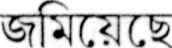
জমিয়েছে
